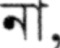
না,
